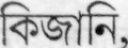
কিজানি,
